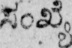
ಸಂಖ್ಯೆ
